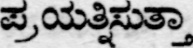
ಪ್ರಯತ್ನಿಸುತ್ತಾ
